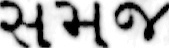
સમજ
